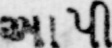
આપી
